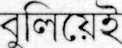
বুলিয়েই
